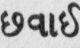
છવાઈ
